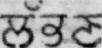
ਲੱਭਣ
